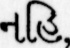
નહિ,
